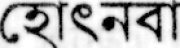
হোৎনবা
